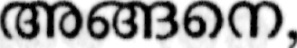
അങ്ങനെ,
